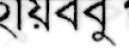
হায়ববু
